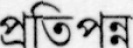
প্রতিপন্ন
